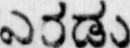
ಎರಡು
